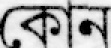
কোন
